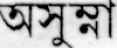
অসুম্না
